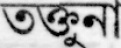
তক্তুনা
